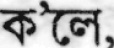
ক'লে,
